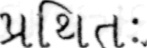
પ્રથિતઃ
